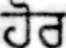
ਹੋਰ
